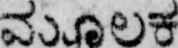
ಮೂಲಕ
